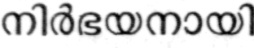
നിര്‍ഭയനായി
